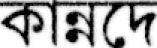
কান্নদে
